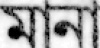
মানা
